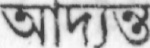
আদ্যন্ত
